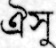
ঐসু
